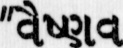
"વૈષ્ણવ
